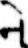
ને
